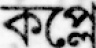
কপ্লে
